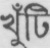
খুঁটি
